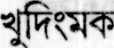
খুদিংমক
